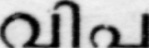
വിപ
